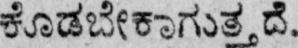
ಕೊಡಬೇಕಾಗುತ್ತದೆ.
